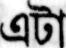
এটা
